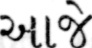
આજે
